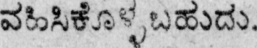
ವಹಿಸಿಕೊಳ್ಳಬಹುದು.
